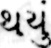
થયું
